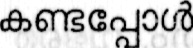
കണ്ടപ്പോള്‍
